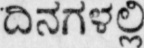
ದಿನಗಳಲ್ಲಿ
